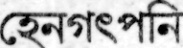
হেনগৎপনি
